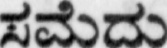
ಸಮೆದು
